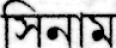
সিনাম
